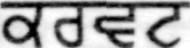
ਕਰਵਟ
